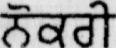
ਨੋਕਰੀ
